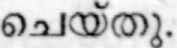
ചെയ്തു.
